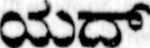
ಯದ್
